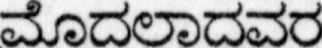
ಮೊದಲಾದವರ
